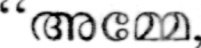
"അമ്മേ,
